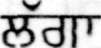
ਲੱਗਾ
